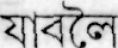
যাবলৈ
